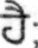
ਹੈ;
